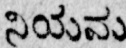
ನಿಯಮ
